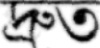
দ্রুত
